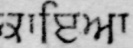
ਕਾਇਆ
